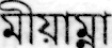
মীয়াম্না
